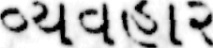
વ્યવહાર
